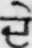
ਦੇ
